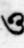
ও
